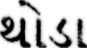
થોડા
